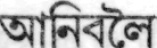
আনিবলৈ
